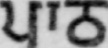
ਪਾਠ
